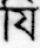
যি
